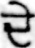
ਦੇ
